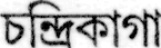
চন্দ্রিকাগা
